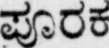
ಪೂರಕ
